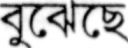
বুঝেছে
